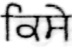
ਕਿਸੇ
